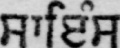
ਸਾਇੰਸ
